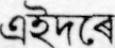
এইদৰে
